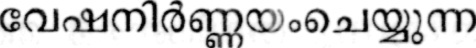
വേഷനിര്‍ണ്ണയംചെയ്യുന്ന
